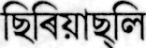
ছিৰিয়াছ্‌লি
